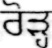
ਰੋੜ੍ਹ
